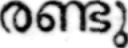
രണ്ടു
